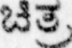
ಚಿತ್ರ
